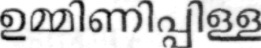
ഉമ്മിണിപ്പിള്ള
